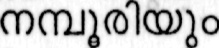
നമ്പൂരിയും
